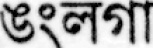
ঙংলগা
